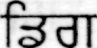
ਡਿਗ
